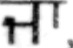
ਜਾ,
